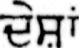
ਦੇਸ਼ਾਂ
